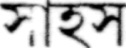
সাহস
